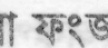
ফংও
